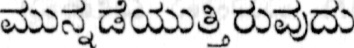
ಮುನ್ನಡೆಯುತ್ತಿರುವುದು
